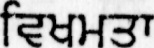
ਵਿਖਮਤਾ
